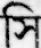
সি
